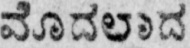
ಮೊದಲಾದ
